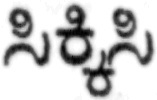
ಸಿಕ್ಕಿಸಿ
